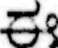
ಈ
